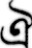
ঐ
